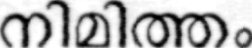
നിമിത്തം
